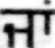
ਜਾਂ
